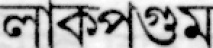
লাকপগুম
